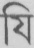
যি
